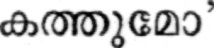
കത്തുമോ’
